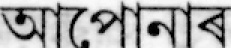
আপোনাৰ
